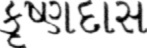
કૃષ્ણદાસ
